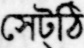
সেট্ঠি
